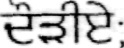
ਦੌੜੀਏ;
